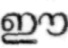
ഈ
